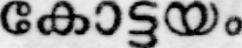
കോട്ടയം
